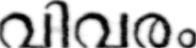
വിവരം
